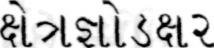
ક્ષેત્રજ્ઞોડક્ષર
